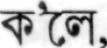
ক'লে,
